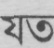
যত
